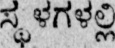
ಸ್ಥಳಗಳಲ್ಲಿ
